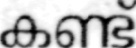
കണ്ട്
